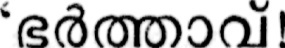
'ഭര്‍ത്താവ്!
